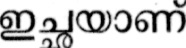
ഇച്ഛയാണ്
